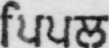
ਪਿਪਲ
